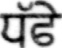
ਧੱਫੇ
